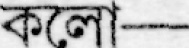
কলো-
